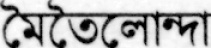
মৈতৈলোন্দা
